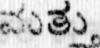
ಮತ್ತು
